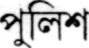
পুলিশ
